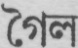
গৈল
